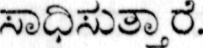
ಸಾಧಿಸುತ್ತಾರೆ.
